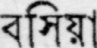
বসিয়া
